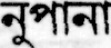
নুপানা
